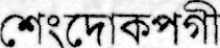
শেংদোকপগী
